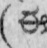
(ಈ
